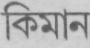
কিমান
